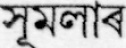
সূমলাৰ
